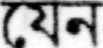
যেন
